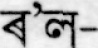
ৰ'ল-
